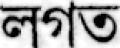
লগত
